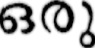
ഒരു
